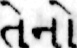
તેનો
